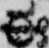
ಈ
